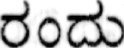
ರಂದು
